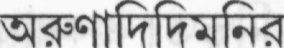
অরুণাদিদিমনির
